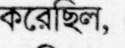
করেছিল,
